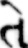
તે
